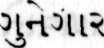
ગુનેગાર
